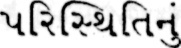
પરિસ્થિતિનું
